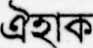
ঐহাক
